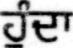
ਹੁੰਦਾ
